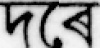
দৰে
